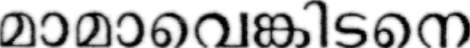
മാമാവെങ്കിടനെ
